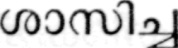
ശാസിച്ച
